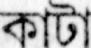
কাটা
